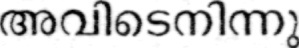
അവിടെനിന്നു
